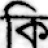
কি
